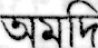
অমদি
